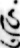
હું
